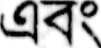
এবং
